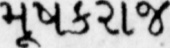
મૂષકરાજ
